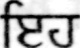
ਇਹ
